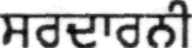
ਸਰਦਾਰਨੀ
